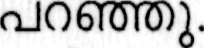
പറഞ്ഞു.
